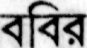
ববির
